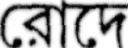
রোদে
